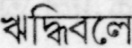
ঋদ্ধিবলে
